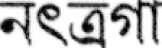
নৎত্রগা
